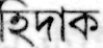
হিদাক
